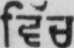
ਵਿੱਚ
